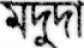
মদুদা
